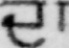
ਦਾ
